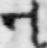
ન
